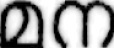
മന
